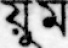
য়ুম
